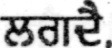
ਲਗਦੈ,
